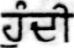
ਹੁੰਦੀ
